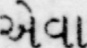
એવા
